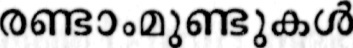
രണ്ടാംമുണ്ടുകള്‍
